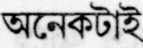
অনেকটাই
